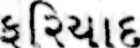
ફરિયાદ
